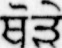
ਥੋੜੇ
